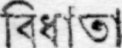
বিধাতা
